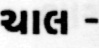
ચાલ-
